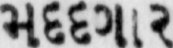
મદદગાર
